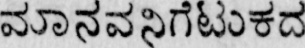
ಮಾನವನಿಗೆಟುಕದ
